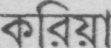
করিয়া
